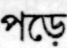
পড়ে
